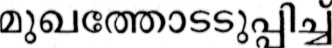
മുഖത്തോടടുപ്പിച്ച്
